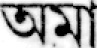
অমা
